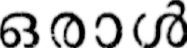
ഒരാള്‍
